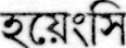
হয়েংসি
